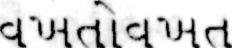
વખતોવખત
